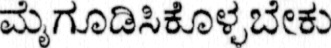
ಮೈಗೂಡಿಸಿಕೊಳ್ಳಬೇಕು
